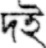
দই
